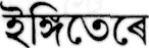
ইঙ্গিতেৰে
